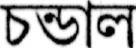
চন্ডাল
